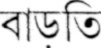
বাড়তি
